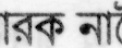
রক না
